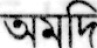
অমদি
